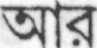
আর
